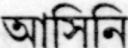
আসিনি
